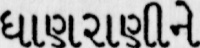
ધાણરાણીને
